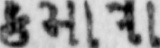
કમાવા
